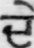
ਦੇ
